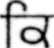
ਕਿ
